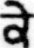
ਕੇ
